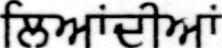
ਲਿਆਂਦੀਆਂ
